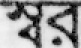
স্বর
